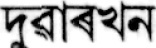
দুৱাৰখন
